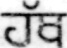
ਹੱਥ
